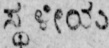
ಸ್ಥಳೀಯ
